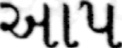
આપ
